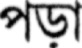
পড়া
